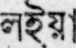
লইয়া
